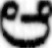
ಆ
